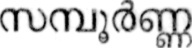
സമ്പൂര്‍ണ്ണ
